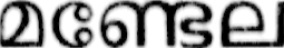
മണ്ടേല
